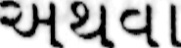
અથવા
